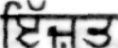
ਇੱਜ਼ਤ
